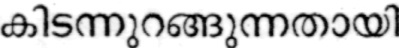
കിടന്നുറങ്ങുന്നതായി
